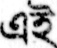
এই
